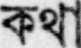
কথা
